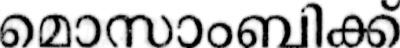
മൊസാംബിക്ക്
